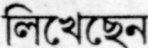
লিখেছেন
